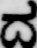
ದ
